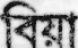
বিয়া
